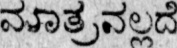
ಮಾತ್ರವಲ್ಲದೆ
